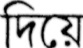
দিয়ে
